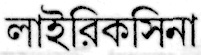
লাইরিকসিনা
